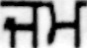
ਜਮ
